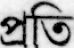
প্রতি
